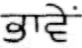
ਭਾਵੇਂ
